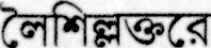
লৈশিল্লক্তরে
